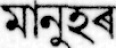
মানুহৰ
